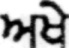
ਅਖੇ
